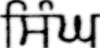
ਸਿੰਘ
